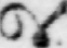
જ
